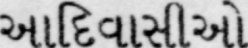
આદિવાસીઓ
